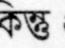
কন্তু
